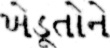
ખેડૂતોને
